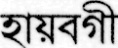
হায়বগী
